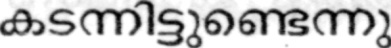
കടന്നിട്ടുണ്ടെന്നു
